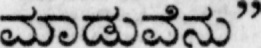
ಮಾಡುವೆನು”
